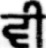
ਵੀ
